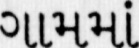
ગામમાં
